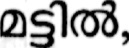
മട്ടില്‍,
